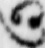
ও
